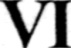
VI
